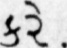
કરે.
